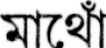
মাথোঁ
